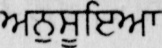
ਅਨੁਸੂਇਆ
